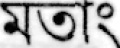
মতাং
